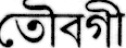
তৌবগী
